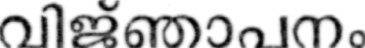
വിജ്ഞാപനം
